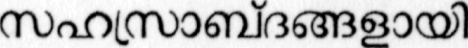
സഹസ്രാബ്ദങ്ങളായി
